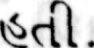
હતી.
